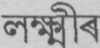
লক্ষ্মীৰ
